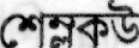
শেম্লকউ
